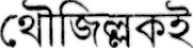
থৌজিল্লকই
